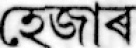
হেজাৰ
